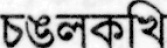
চঙলকখি
